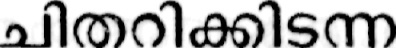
ചിതറിക്കിടന്ന
